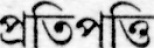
প্রতিপত্তি
